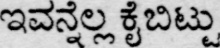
ಇವನ್ನೆಲ್ಲಕೈಬಿಟ್ಟು
